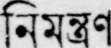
নিমন্ত্রণ
